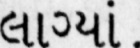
લાગ્યાં.
